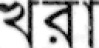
খরা
